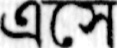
এসে
